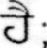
ਹੈ;
